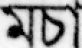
মচা
